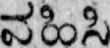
ವಹಿಸಿ
